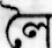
লৈ
